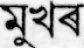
মুখৰ
